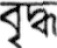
বৃদ্ধ
